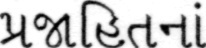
પ્રજાહિતનાં
